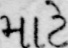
માટે
